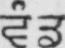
ਵੰਡ
